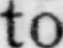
to
